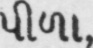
પીળા,
